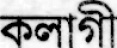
কলাগী
